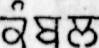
ਕੰਬਲ
